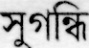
সুগন্ধি
